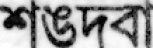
শঙদবা
